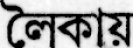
লৈকায়
